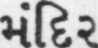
મંદિરે
